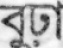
বুঢ়া
